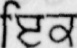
ਇਕ
